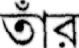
তাঁর
